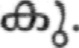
കു.
